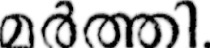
മര്‍ത്തി.
